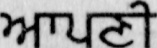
ਆਪਣੀ
